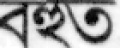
বহুত
